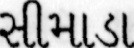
સીમાડા
